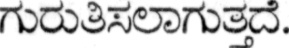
ಗುರುತಿಸಲಾಗುತ್ತದೆ.
